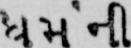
ધર્મની
